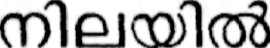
നിലയില്‍
